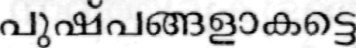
പുഷ്പങ്ങളാകട്ടെ
